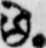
છે.
